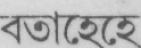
বতাহেহে
